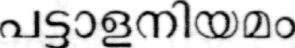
പട്ടാളനിയമം
